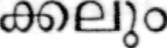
ക്കലും
